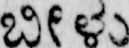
ಬೀಳು
